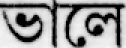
ভালে
